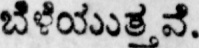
ಬೆಳೆಯುತ್ತವೆ.
